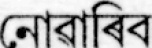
নোৱাৰিব
